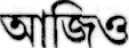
আজিও
